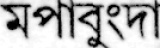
মপাবুংদা
